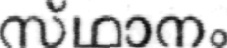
സ്ഥാനം
